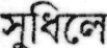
সুধিলে
